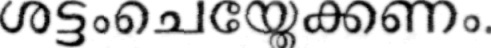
ശട്ടംചെയ്തേക്കണം.
